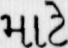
માટે
